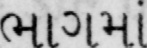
ભાગમાં
